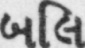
બલિ
